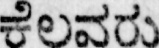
ಕೆಲವರು
